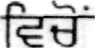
ਵਿਚੋਂ
